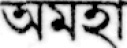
অমহা
